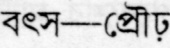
বত্স–প্রৌঢ়
